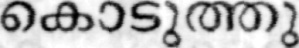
കൊടുത്തു
